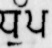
ਧੁੱਪ
